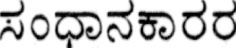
ಸಂಧಾನಕಾರರ
